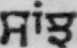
ਸਾਂਝ
